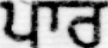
ਪਾਰ
